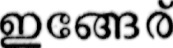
ഇങ്ങേര്
